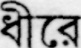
ধীরে
